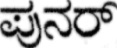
ಪುನರ್
